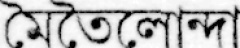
মৈতৈলোন্দা
